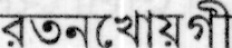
রতনখোয়গী
